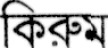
কিরুম
